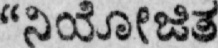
“ನಿಯೋಜಿತ
